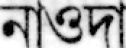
নাওদা
